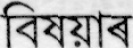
বিষয়াৰ
